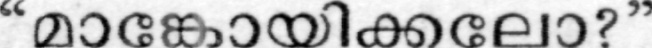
"മാങ്കോയിക്കലോ?”
